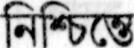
নিশ্চিন্তে
